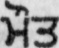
ਮੌਤ
